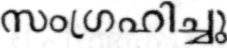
സംഗ്രഹിച്ചു
